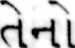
તેનો
